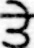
ਤੇ
